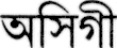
অসিগী
